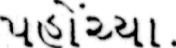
પહોંચ્યા.
